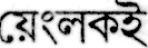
য়েংলকই
